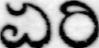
ಏರಿ
